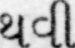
થવી
